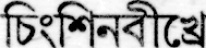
চিংশিনবীখ্রে
